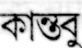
কান্তবু
